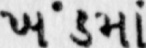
ખંડમાં
